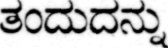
ತಂದುದನ್ನು
